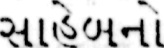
સાહેબનો
